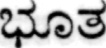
ಭೂತ
